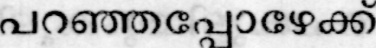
പറഞ്ഞപ്പോഴേക്ക്
